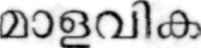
മാളവിക
